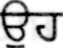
ਉਹ
